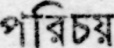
পরিচয়
